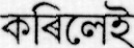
কৰিলেই
